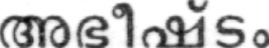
അഭീഷ്ടം
